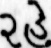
રહે
